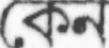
কেন
